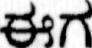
ಈಗ
